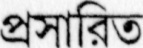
প্রসারিত
